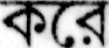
করে
